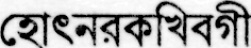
হোৎনরকখিবগী
